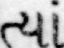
ત્યાં
